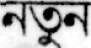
নতুন
